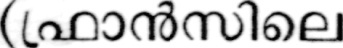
(ഫ്രാന്‍സിലെ
